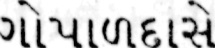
ગોપાળદાસે
